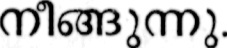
നീങ്ങുന്നു.
